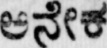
ಅನೇಕ
